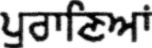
ਪੁਰਾਣਿਆਂ
